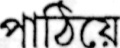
পাঠিয়ে
